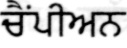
ਚੈਂਪੀਅਨ
